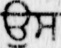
ਉਸ
